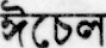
ঈচেল
